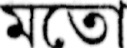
মতো
